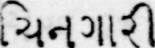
ચિનગારી
